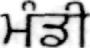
ਮੰਡੀ
